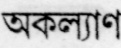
অকল্যাণ
